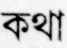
কথা
